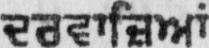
ਦਰਵਾਜ਼ਿਆਂ
